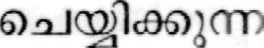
ചെയ്യിക്കുന്ന
